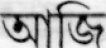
আজি
